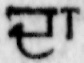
ਦਾ
